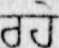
ਰਹੇ
